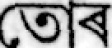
তোৰ
